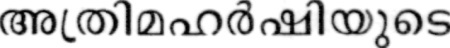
അത്രിമഹര്‍ഷിയുടെ
